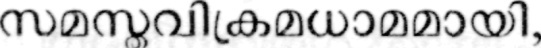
സമസ്തവിക്രമധാമമായി,
